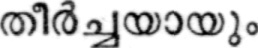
തീര്‍ച്ചയായും
